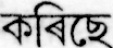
কৰিছে
